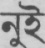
নুই
